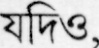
যদিও,
